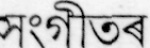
সংগীতৰ
